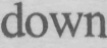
down
